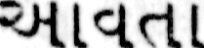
આવતા
